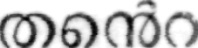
തന്റെ
